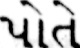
પોતે
